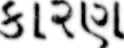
કારણ
